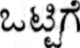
ಒಟ್ಟಿಗೆ
